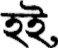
হই,
